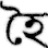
হৈ
